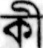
কী
